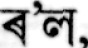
ৰ'ল,
